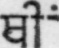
ਥੀਂ
